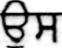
ਉਸ
